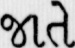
જાતે
